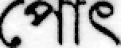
পোৎ
